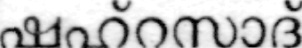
ഷഹ്റസാദ്
